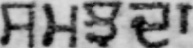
ਸਮਝਦਾ
